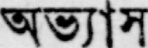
অভ্যাস
